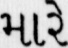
મારે
